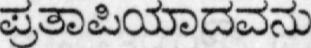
ಪ್ರತಾಪಿಯಾದವನು
